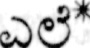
ಎಲೆ*
